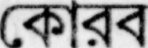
কোরব
